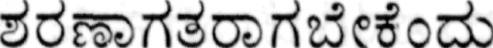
ಶರಣಾಗತರಾಗಬೇಕೆಂದು
